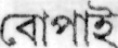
বোপাই
